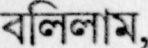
বলিলাম,
